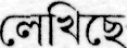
লেখিছে
